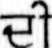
ਦੀ
